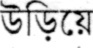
উড়িয়ে
